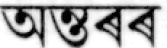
অন্তৰৰ
